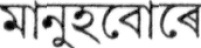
মানুহবোৰে
